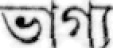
ভাগ্য
